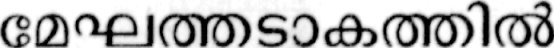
മേഘത്തടാകത്തില്‍
